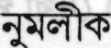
নুমলীক
